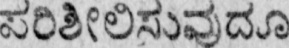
ಪರಿಶೀಲಿಸುವುದೂ
